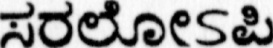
ಸರಲೋsಪಿ
